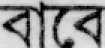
বাবে
